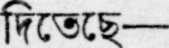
দিতেছে—
